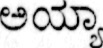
ಅಯ್ಯಾ
